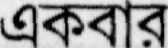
একবার
